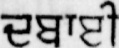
ਦਬਾਈ
